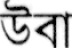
উবা
